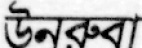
উনরুবা
